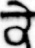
ਕੇ
